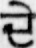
ਦੇ
